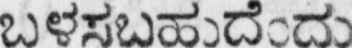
ಬಳಸಬಹುದೆಂದು
